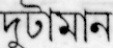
দুটামান
